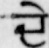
ਦੇ
